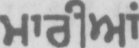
ਮਾਰੀਆਂ
